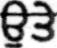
ਉਤੇ
